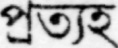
প্রত্যহ
